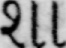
શા
